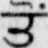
ਤੋਂ
